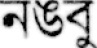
নঙবু
